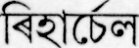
ৰিহার্চেল
